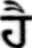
ਹੈ
